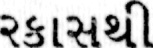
રકાસથી
